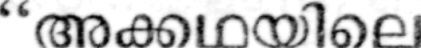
"അക്കഥയിലെ
